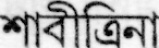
শাবীত্রিনা
